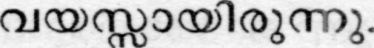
വയസ്സായിരുന്നു.
